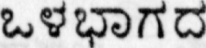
ಒಳಭಾಗದ
